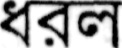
ধরল
